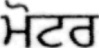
ਮੋਟਰ
